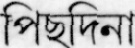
পিছদিনা
